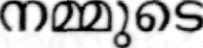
നമ്മുടെ
